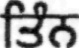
ਤਿੰਨ
